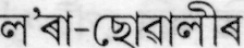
ল'ৰা-ছোৱালীৰ
